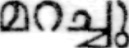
മറച്ചു
